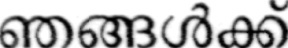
ഞങ്ങള്‍ക്ക്
